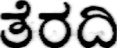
ತೆರದಿ
